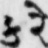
કરે
